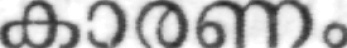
കാരണം
